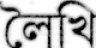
লৈখি
